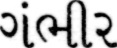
ગંભીર
